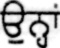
ਉਨ੍ਹਾਂ
